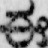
ಈ
